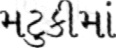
મટુકીમાં
